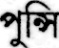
পুন্সি
